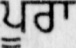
ਪੂਰਾ
